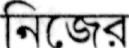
নিজের
